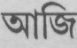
আজি
